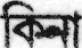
কিনা
